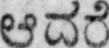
ಆದರೆ
